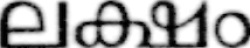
ലക്ഷം
